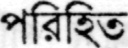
পরিহিত
